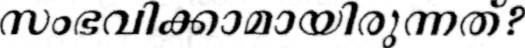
സംഭവിക്കാമായിരുന്നത്?
